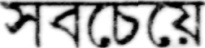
সবচেয়ে
